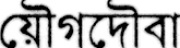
য়ৌগদৌবা
